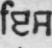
ਇਸ
